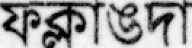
ফক্লাঙদা
